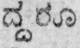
ದ್ದರೂ
